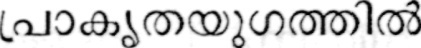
പ്രാകൃതയുഗത്തില്‍
